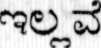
ಇಲ್ಲವೆ
